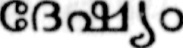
ദേഷ്യം
